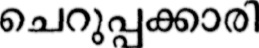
ചെറുപ്പക്കാരി
